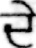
ਦੇ
